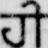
ਹੀ
